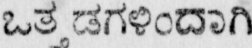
ಒತ್ತಡಗಳಿಂದಾಗಿ
